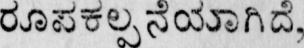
ರೂಪಕಲ್ಪನೆಯಾಗಿದೆ,
